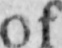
of
